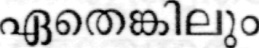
ഏതെങ്കിലും
